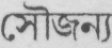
সৌজন্য
